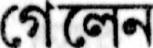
গেলেন
